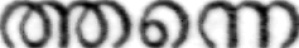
ത്തന്നെ
